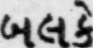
બલકે
